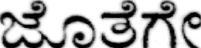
ಜೊತೆಗೇ
